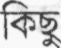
কিছু
